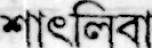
শাৎলিবা
